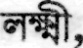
লক্ষ্মী,
